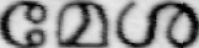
മേശ
